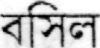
বসিল
